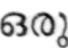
ഒരു
